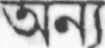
অন্য
